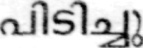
പിടിച്ചു
